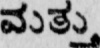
ಮತ್ತು
